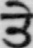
ਤੇ
